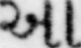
આ
